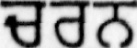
ਚਰਨ
